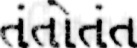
તંતોતંત
